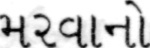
મરવાનો
